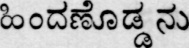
ಹಿಂದಣೊಡ್ಡನು
